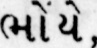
ભોંયે,
